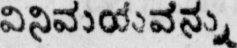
ವಿನಿಮಯವನ್ನು
